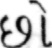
છો
